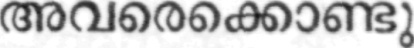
അവരെക്കൊണ്ടു
